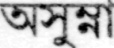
অসুম্না
